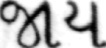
જાય
